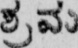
ಶ್ರಮ
